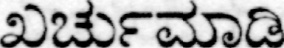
ಖರ್ಚುಮಾಡಿ
